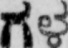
ಗಳ
